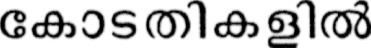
കോടതികളില്‍
